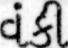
વંકી
